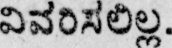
ವಿವರಿಸಲಿಲ್ಲ.
